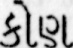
કોણ
